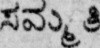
ಸಮ್ಮತಿ
